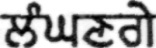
ਲੰਘਣਗੇ
